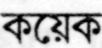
কয়েক
